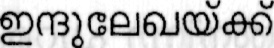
ഇന്ദുലേഖയ്ക്ക്
